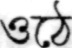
ওঠে
